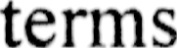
terms
